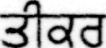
ਤੀਕਰ
